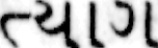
ત્યાગ
